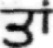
ਤਾਂ
